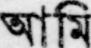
আমি
